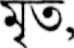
মৃত,
